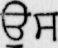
ਉਸ
